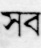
সব
